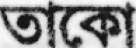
তাকো
